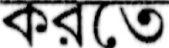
করতে
